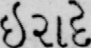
ઇરાદે
